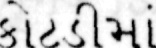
કોટડીમાં
